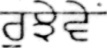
ਰੁਝੇਵੇ
